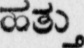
ಹತ್ತು
